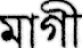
মাগী
